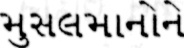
મુસલમાનોને
